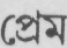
প্ৰেম
